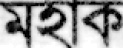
মহাক
